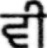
ਵੀ
